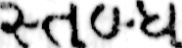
સ્તબ્ધ
